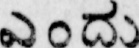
ಎಂದು
